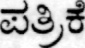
ಪತ್ರಿಕೆ
